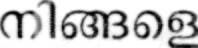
നിങ്ങളെ
